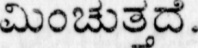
ಮಿಂಚುತ್ತದೆ.
